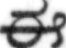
ಈ
